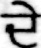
ਦੇ
